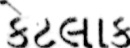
કેટલાક
